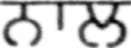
ਨਾਲ
